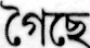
গৈছে
